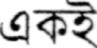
একই
